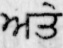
ਅਤੇ
